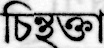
চিন্থক্তা
